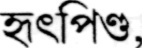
হৃৎপিণ্ড,
